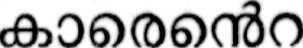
കാരെന്റെ
